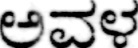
ಅವಳ
